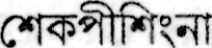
শেকপীশিংনা
